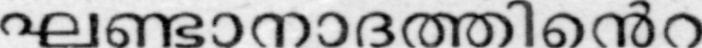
ഘണ്ടാനാദത്തിന്റെ
